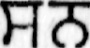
ਸਨ
